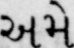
અમે
